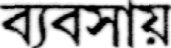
ব্যবসায়
